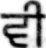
ਵੀ
